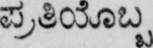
ಪ್ರತಿಯೊಬ್ಬ
